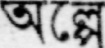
অল্পে
